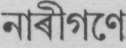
নাৰীগণে
